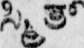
ಸ್ಮಿತ್
